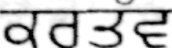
ਕਰਤੱਵ
